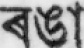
ৰঙা
